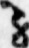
કે
